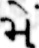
મેં
